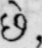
છે,
